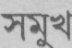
সমুখ
